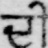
ਦੀ
